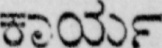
ಕಾರ್ಯ
